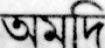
অমদি
